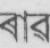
ৰাৱ
